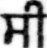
ਸੀ
